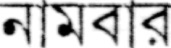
নামবার
